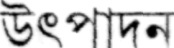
উত্পাদন
